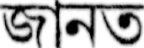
জানত
